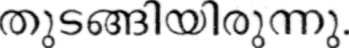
തുടങ്ങിയിരുന്നു.
